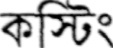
কস্টিং
